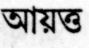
আয়ত্ত
